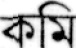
কমি
